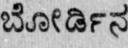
ಬೋರ್ಡಿನ
